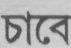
চাবে
